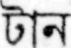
টান
